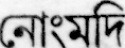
নোংমদি
